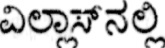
ವಿಲ್ಲಾಸ್ನಲ್ಲಿ
